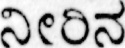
ನೀರಿನ
